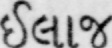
ઈલાજ
